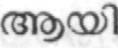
ആയി
